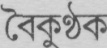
বৈকুণ্ঠক
